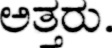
ಅತ್ತರು.
